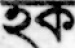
হক
